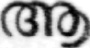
ആ
